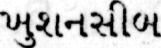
ખુશનસીબ
